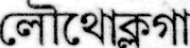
লৌথোক্লগা
